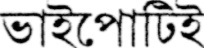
ভাইপোটিই
